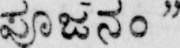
ಪೂಜನಂ”
